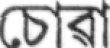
চোৱা
